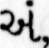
અં,
